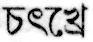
চৎখ্রে
